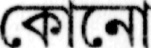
কোনো
